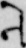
ને
